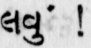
લવું!
